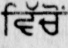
ਵਿੱਚੋਂ
